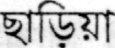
ছাড়িয়া
